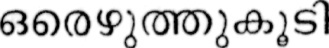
ഒരെഴുത്തുകൂടി
